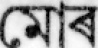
মোৰ
